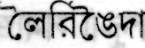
লৈরিঙৈদা
